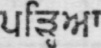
ਪੜ੍ਹਿਆ
